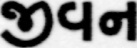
જીવન
